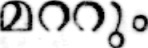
മററും
